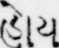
હોય
